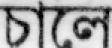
চালে
